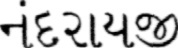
નંદરાયજી
